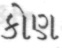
કોણ
